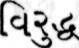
વિરુદ્ધ
